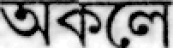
অকলে
